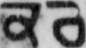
ਕਰ
